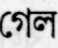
গেল
